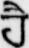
ਹੈ
